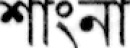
শাংনা
